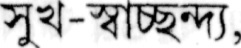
সুখ-স্বাচ্ছন্দ্য,
